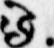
છે.
